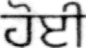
ਹੋਈ
